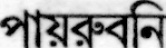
পায়রুবনি
